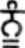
ਨੁੰ
